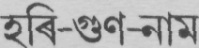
হৰি-গুণ-নাম-
